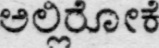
ಅಲ್ಲಿರೋಕೆ
